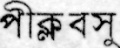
পীক্লবসু
